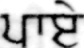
ਪਾਏ
